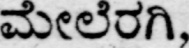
ಮೇಲೆರಗಿ,
